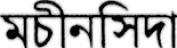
মচীনসিদা
